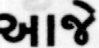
આજે
